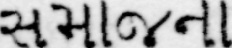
સમાજના
